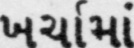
ખર્ચામાં
